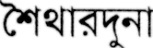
শৈথারদুনা
